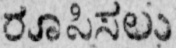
ರೂಪಿಸಲು
